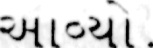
આવ્યો.
